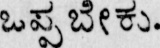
ಒಪ್ಪಬೇಕು.
